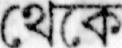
থেকে
